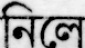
নিলে
